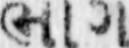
ભાગ
